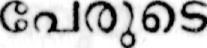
പേരുടെ
